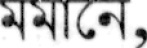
মমানে,
